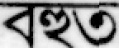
বহুত
